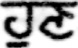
ਹੁਣ
